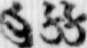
હક્ક
